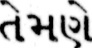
તેમને
